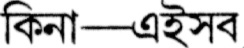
কিনা-এইসব
